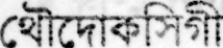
থৌদোকসিগী
